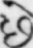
છે
